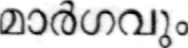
മാര്‍ഗവും
